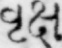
વૃક્ષ
